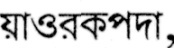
য়াওরকপদা,
